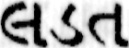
લડત
